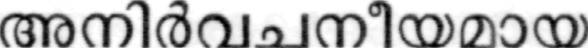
അനിര്‍വചനീയമായ
